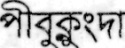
পীবুক্নুংদা
